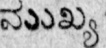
ಮುಖ್ಯ
